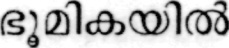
ഭൂമികയില്‍
